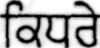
ਕਿਧਰੇ
